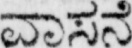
ವಾಸನೆ
